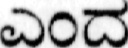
ಎಂದ
